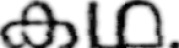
കഥ.
